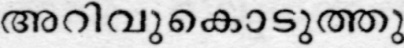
അറിവുകൊടുത്തു
